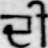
ਦੀ
